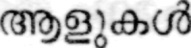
ആളുകള്‍
